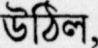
উঠিল,
